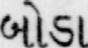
બોડા
